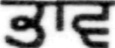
ਭਾਵ
